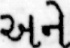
અને
